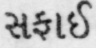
સફાઈ
